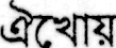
ঐখোয়
